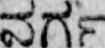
ವರ್ಗ
